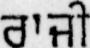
ਰਾਜੀ
